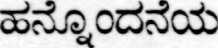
ಹನ್ನೊಂದನೆಯ
